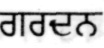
ਗਰਦਨ
